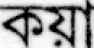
কয়া
